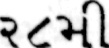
૨૮મી
